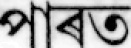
পাৰত
